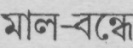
মাল-বন্ধে
